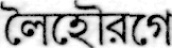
লৈহৌরগে
